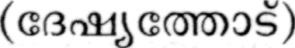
(ദേഷ്യത്തോട്)
